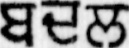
ਬਦਲ
